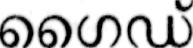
ഗൈഡ്
